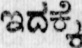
ಇದಕ್ಕೆ
